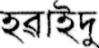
হৱাইদু
